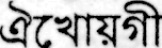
ঐখোয়গী
